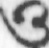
ও
